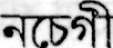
নচেগী
